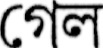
গেল
